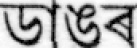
ডাঙৰ
